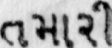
તમારી
